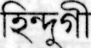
হিন্দুগী
